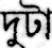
দুটা
